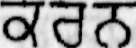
ਕਰਨ
